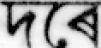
দৰে
